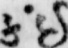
કંઈ
